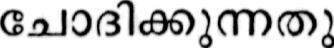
ചോദിക്കുന്നതു
